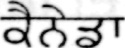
ਕੈਨੇਡਾ
